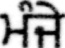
ਮੰਜੇ
